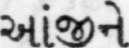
આંજીને
